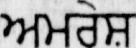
ਅਮਰੇਸ਼
